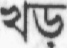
খড়
